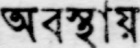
অবস্থায়
